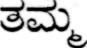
ತಮ್ಮ
